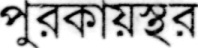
পুরকায়স্থর
